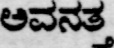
ಅವನತ್ತ
